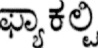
ಫ್ಯಾಕಲ್ಟಿ
